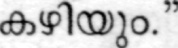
കഴിയും.”
